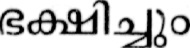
ഭക്ഷിച്ചും
